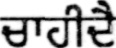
ਚਾਹੀਦੈ
